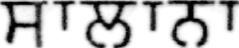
ਸਾਲਾਨਾ
